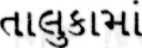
તાલુકામાં
